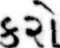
કરો
